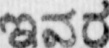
ಇವರ
